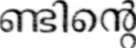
ണ്ടിന്റെ
